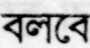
বলবে
